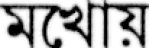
মখোয়
